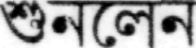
শুনলেন
